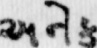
અનેક
